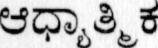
ಆಧ್ಯಾತ್ಮಿಕ
